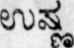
ಉಷ್ಣ
